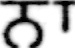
ਨਾ
